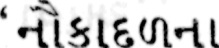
"નૌકાદળના
